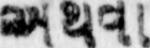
અથવા
